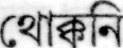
থোক্কনি
